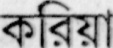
করিয়া
